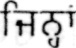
ਜਿਨ੍ਹਾਂ
